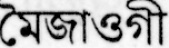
মৈজাওগী
